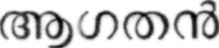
ആഗതന്‍
